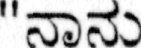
“ನಾನು
